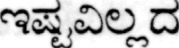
ಇಷ್ಟವಿಲ್ಲದ
